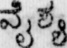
ವೈಶ್ಯ
